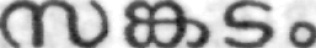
സങ്കടം
